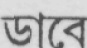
ডাবে
